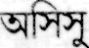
অসিসু
